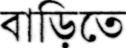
বাড়িতে
